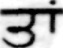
ਤਾਂ
